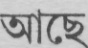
আছে
